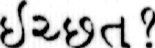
ઇચ્છત?
